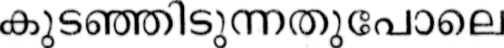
കുടഞ്ഞിടുന്നതുപോലെ
